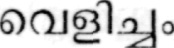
വെളിച്ചം
